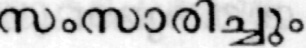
സംസാരിച്ചും
